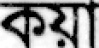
কয়া
